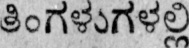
ತಿಂಗಳುಗಳಲ್ಲಿ
